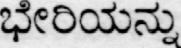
ಭೇರಿಯನ್ನು
